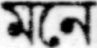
মনে
